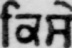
ਕਿਸੇ
